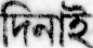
দিনাই
